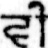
ਵੀ
